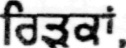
ਰਿੜਕਾਂ,
